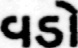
વડો
